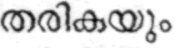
തരികയും
